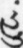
હું
